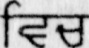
ਵਿਚ
